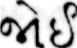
જોઈ
